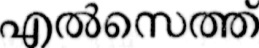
എല്‍സെത്ത്
